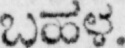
ಬಹಳ.
